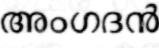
അംഗദന്‍
